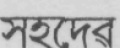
সহদেৱ
